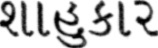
શાહુકાર
